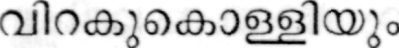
വിറകുകൊള്ളിയും
